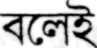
বলেই
